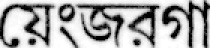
য়েংজরগা
